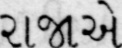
રાજાએ
